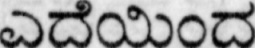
ಎದೆಯಿಂದ
